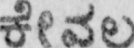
ಕೇವಲ
